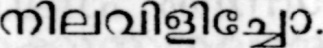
നിലവിളിച്ചോ.
